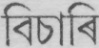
বিচাৰি
